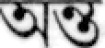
অন্ত
